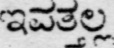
ಇವತ್ತಲ್ಲ
